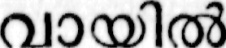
വായില്‍
